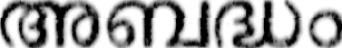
അബദ്ധം
